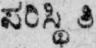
ಪರಿಸ್ಥಿತಿ
